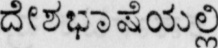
ದೇಶಭಾಷೆಯಲ್ಲಿ
